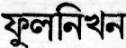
ফুলনিখন
